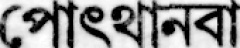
পোৎথানবা
